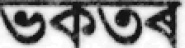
ভকতৰ
